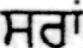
ਸਰਾਂ
